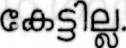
കേട്ടില്ല.
